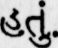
હતું.
